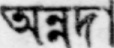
অন্নদা
